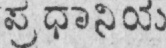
ಪ್ರಧಾನಿಯ
